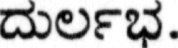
ದುರ್ಲಭ.
